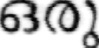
ഒരു
